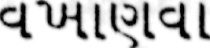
વખાણવા
